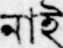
নাই
